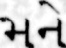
મને
